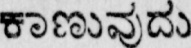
ಕಾಣುವುದು
